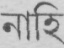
নাহি
